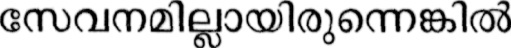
സേവനമില്ലായിരുന്നെങ്കില്‍
